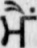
ਮੈਂ
